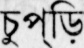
চুপ্‌ড়ি
